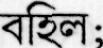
বহিল;
